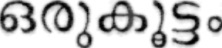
ഒരുകൂട്ടം
